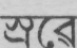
স্ৰৱে
